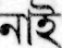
নাই
